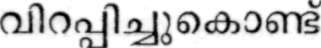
വിറപ്പിച്ചുകൊണ്ട്
